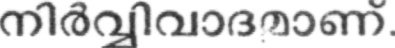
നിര്‍വ്വിവാദമാണ്.
